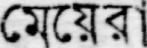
মেয়েরা
